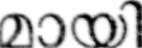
മായി
